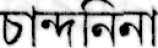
চান্দনিনা
